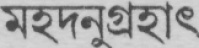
মহদনুগ্ৰহাৎ
